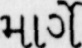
માર્ગે
